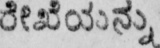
ರೇಖೆಯನ್ನು
